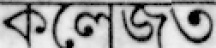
কলেজত
